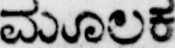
ಮೂಲಕ
